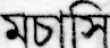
মচাসি
